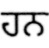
ਹਨ
